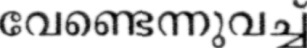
വേണ്ടെന്നുവച്ച്
